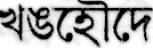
খঙহৌদে
